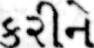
કરીને
